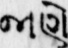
જાણે
